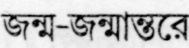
জন্ম-জন্মান্তরে
